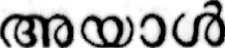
അയാള്‍
